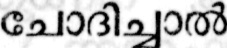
ചോദിച്ചാല്‍
